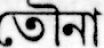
তৌনা
